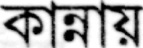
কান্নায়
